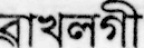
ৱাখলগী
